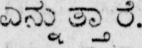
ಎನ್ನುತ್ತಾರೆ.
